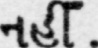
નહીં.
